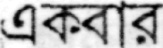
একবার
